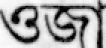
ওজা
